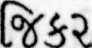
જિકર
